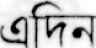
এদিন
